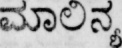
ಮಾಲಿನ್ಯ
